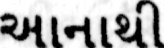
આનાથી
